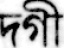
দগী
